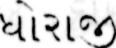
ધોરાજી
